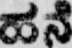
ಹನೆ
